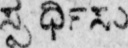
ಸ್ಪರ್ಧಿಸು
